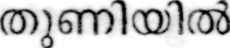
തുണിയില്‍
